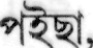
পইছা,
